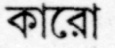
কারো
